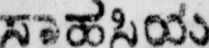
ಸಾಹಸಿಯ
